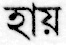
হায়
